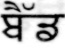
ਬੈੱਡ
